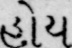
હોય
